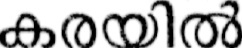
കരയില്‍
